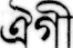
ঐগী
